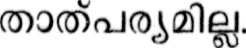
താത്പര്യമില്ല.
